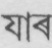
যাৰ
